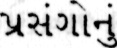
પ્રસંગોનું
